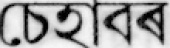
চেহাবৰ
